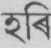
হৰি
